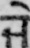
ਜੇ
